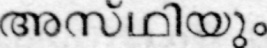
അസ്ഥിയും
